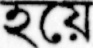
হয়ে
